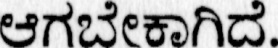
ಆಗಬೇಕಾಗಿದೆ.
